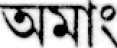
অমাং
